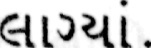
લાગ્યાં.
